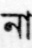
না
